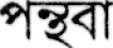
পন্থবা
